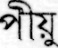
পীয়ু
